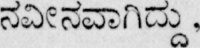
ನವೀನವಾಗಿದ್ದು,
